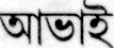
আভাই
